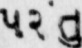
પરંતુ
